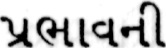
પ્રભાવની
